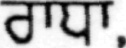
ਰਾਧਾ,
